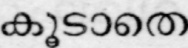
കൂടാതെ
